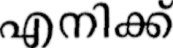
എനിക്ക്
